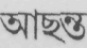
আছন্ত
